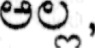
ಅಲ್ಲ,
